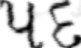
પદ
